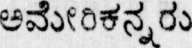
ಅಮೇರಿಕನ್ನರು
